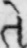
તે
